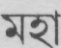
মহা
